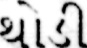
થોડી
